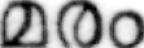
മരം
